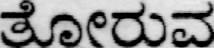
ತೋರುವ
